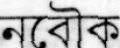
নবৌক
